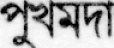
পুখমদা
